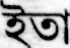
ইতা
